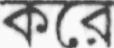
করে
